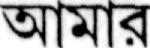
আমার
